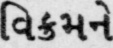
વિક્રમને
